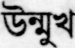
উন্মুখ
